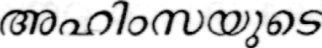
അഹിംസയുടെ
